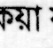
কয়া
